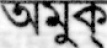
অমুক্
